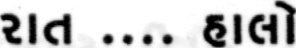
રાત...હાલો
